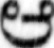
ಆ
